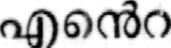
എന്റെ
